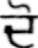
ਦੋ
